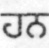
ਹਨ
